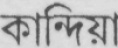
কান্দিয়া
